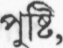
পুষ্টি,
